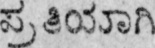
ಪ್ರತಿಯಾಗಿ
